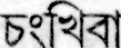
চংখিবা
